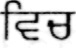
ਵਿਚ
